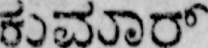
ಕುಮಾರ್
